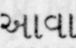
આવા
